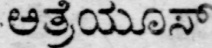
ಅತ್ರೆಯೂಸ್
